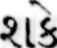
શકે
